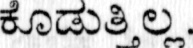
ಕೊಡುತ್ತಿಲ್ಲ.
